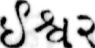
ઈશ્વર
